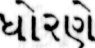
ધોરણે
